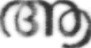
ആ
